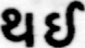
થઈ
